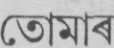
তোমাৰ
